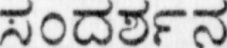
ಸಂದರ್ಶನ
